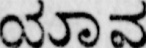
ಯಾವ
